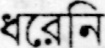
ধরেনি
